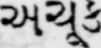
અચૂક
